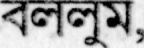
বললুম,
